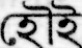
হৌই
